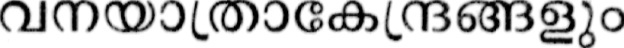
വനയാത്രാകേന്ദ്രങ്ങളും
